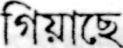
গিয়াছে
